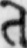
તે
